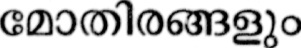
മോതിരങ്ങളും
